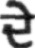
ਦੇ
